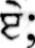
ਏ;
